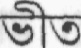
ভীত
